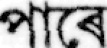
পাৰে
